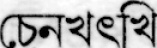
চেনখৎখি
